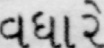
વધારે
